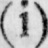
(i)
